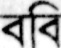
ববি
